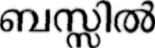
ബസ്സില്‍
